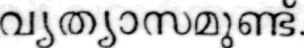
വ്യത്യാസമുണ്ട്.
